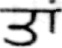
ਤਾਂ
